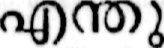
എന്തു
